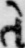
તે
